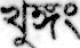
খুঙ্গং
